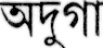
অদুগা
